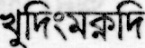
খুদিংমক্নদি
